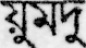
য়ুমদু
